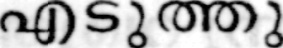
എടുത്തു
